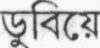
ডুবিয়ে
